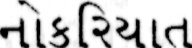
નોકરિયાત
